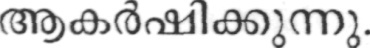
ആകര്‍ഷിക്കുന്നു.
